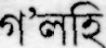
গ'লহি
